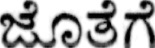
ಜೊತೆಗೆ
